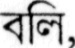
বলি,
